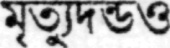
মৃত্যুদন্ডও
